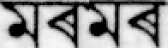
মৰমৰ
